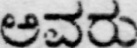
ಅವರು
